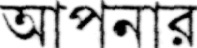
আপনার
